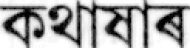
কথাষাৰ
